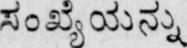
ಸಂಖ್ಯೆಯನ್ನು
